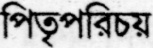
পিতৃপরিচয়
